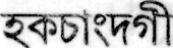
হকচাংদগী
